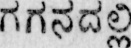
ಗಗನದಲ್ಲಿ
